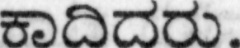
ಕಾದಿದರು.
